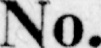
No.
